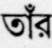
তাঁর
